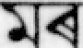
মৰ
